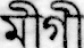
মীগী
